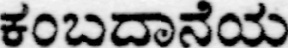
ಕಂಬದಾನೆಯ
